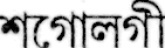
শগোলগী
